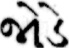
જોડે
